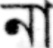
না
